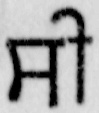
ਸੀ
